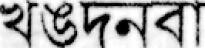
খঙদনবা
